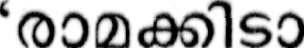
‘രാമക്കിടാ
